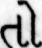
તો
